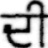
ਦੀ
